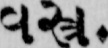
વસ્ત્ર.
